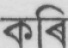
কৰি
